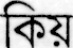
কিয়
